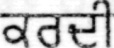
ਕਰਦੀ
